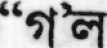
"গ'ল
